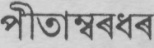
পীতাম্বৰধৰ
